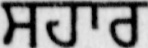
ਸਹਾਰ
